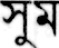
সুম
